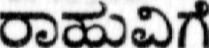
ರಾಹುವಿಗೆ
